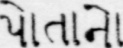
પોતાનો
